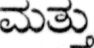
ಮತ್ತು
